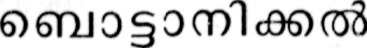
ബൊട്ടാനിക്കല്‍
